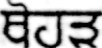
ਥੋਹੜ
